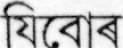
যিবোৰ
